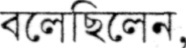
বলেছিলেন,
